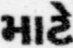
માટે
